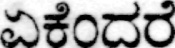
ಏಕೆಂದರೆ
